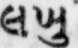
લખું
